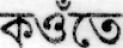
কওঁতে
